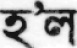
হ'ল
